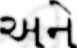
અને
